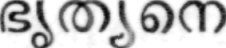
ഭൃത്യനെ
